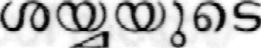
ശയ്യയുടെ
